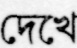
দেখে
